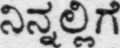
ನಿನ್ನಲ್ಲಿಗೆ
